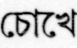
চোখে
